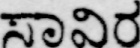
ಸಾವಿರ
